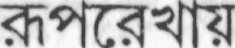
রূপরেখায়
